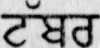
ਟੱਬਰ
